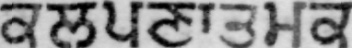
ਕਲਪਣਾਤਮਕ
